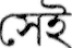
সেই
